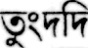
তুংদদি
